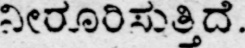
ನೀರೂರಿಸುತ್ತಿದೆ.
